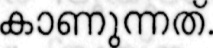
കാണുന്നത്.
